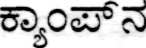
ಕ್ಯಾಂಪ್ನ
